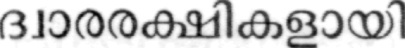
ദ്വാരരക്ഷികളായി
